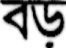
বড়
